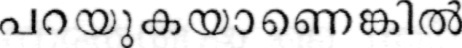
പറയുകയാണെങ്കില്‍
